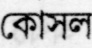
কোসল
